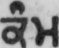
ਕੰਮ
